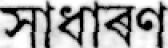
সাধাৰণ
